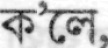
ক'লে,
